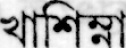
খাশিম্না
